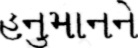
હનુમાનને
